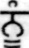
ਨੂੰ
